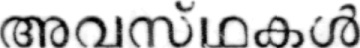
അവസ്ഥകള്‍
